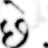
છે.
